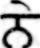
ਨੇ
